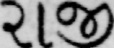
રાજી
